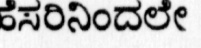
ಹೆಸರಿನಿಂದಲೇ
